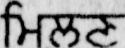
ਮਿਲਣ
